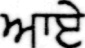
ਆਏ
